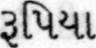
રૂપિયા
